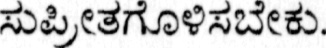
ಸುಪ್ರೀತಗೊಳಿಸಬೇಕು.
